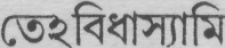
তেহবিধাস্যামি
